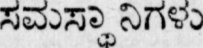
ಸಮಸ್ಥಾನಿಗಳು
